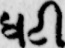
ધટી
